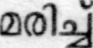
മരിച്ച്
